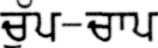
ਚੁੱਪ-ਚਾਪ
